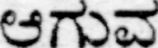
ಆಗುವ
